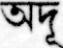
অদূ
